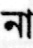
না
